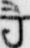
ਹੈ
